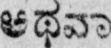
ಅಥವಾ
